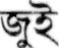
জুই
